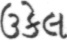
ઉકેલ
